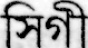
সিগী
